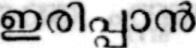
ഇരിപ്പാന്‍
